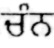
ਚੰਨ
